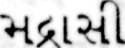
મદ્રાસી
